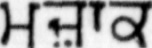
ਮਜ਼ਾਕ
